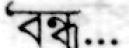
'বন্ধ...
